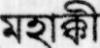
মহাক্কী
